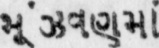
મૂંઝવણમાં
